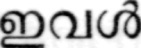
ഇവള്‍
